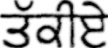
ਤੱਕੀਏ
